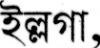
ইল্লগা,
